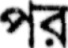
পর
